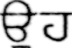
ਉਹ
